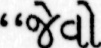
"જેવો
